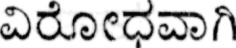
ವಿರೋಧವಾಗಿ
